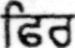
ਫਿਰ
